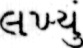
લખ્યું
